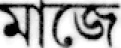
মাজে
